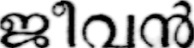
ജീവന്‍
